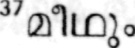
37മീഥും
